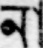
না
